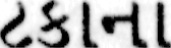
ટકાના
